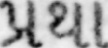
પ્રથા
